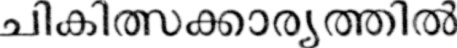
ചികിത്സക്കാര്യത്തില്‍
